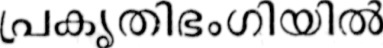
പ്രകൃതിഭംഗിയില്‍
